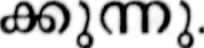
ക്കുന്നു.
